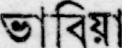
ভাবিয়া
